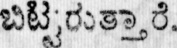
ಬಿಟ್ಟಿರುತ್ತಾರೆ.
